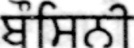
ਬੌਸਿਨੀ
